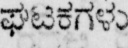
ಘಟಕಗಳು
